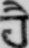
ਹੈ
